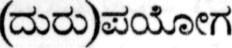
(ದುರು)ಪಯೋಗ
